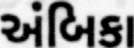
અંબિકા
